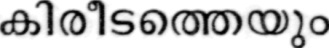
കിരീടത്തെയും
